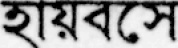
হায়বসে
